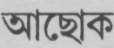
আছোক
